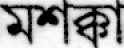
মশক্কা
